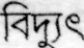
বিদ্যুৎ
